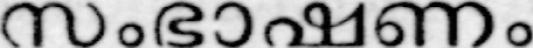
സംഭാഷണം
